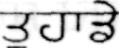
ਤੁਹਾਡੇ
